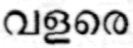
വളരെ
